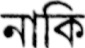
নাকি
